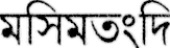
মসিমতংদি
